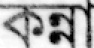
কন্না
